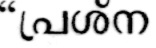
“പ്രശ്‌ന
